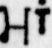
ਮਾਂ
